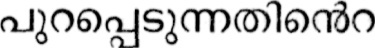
പുറപ്പെടുന്നതിന്റെ
